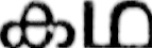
കഥ
